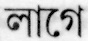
লাগে
